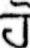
ਹੋ
